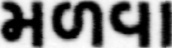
મળવા
